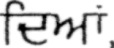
ਦਿਆਂ,
